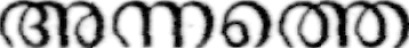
അന്നത്തെ
